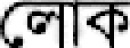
লোক
